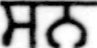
ਸਨ
